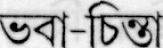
ভবা-চিন্তা
